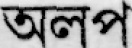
অলপ
